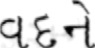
વદને
